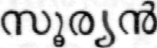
സൂര്യന്‍
